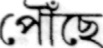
পৌঁছে
